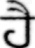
ਹੈ
